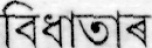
বিধাতাৰ
